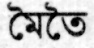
মৈতৈ
